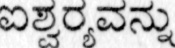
ಐಶ್ವರ್‍ಯವನ್ನು
